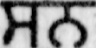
ਸਨ
